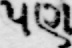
પણ
